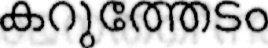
കറുത്തേടം
